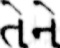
તેને
